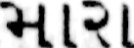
મારા
